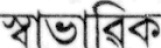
স্বাভাৱিক
